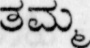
ತಮ್ಮ
